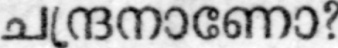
ചന്ദ്രനാണോ?
